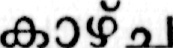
കാഴ്ച
